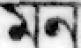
মন
